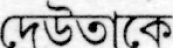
দেউতাকে
